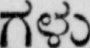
ಗಳು
